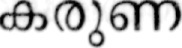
കരുണ
